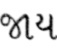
જાય
